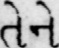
તેને
